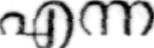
എന്ന
